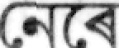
নেৰে
